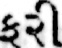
ફરી
